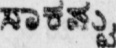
ಸಾಕಷ್ಟು
